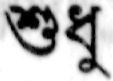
শুধু
